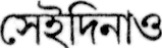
সেইদিনাও
